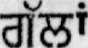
ਗੱਲਾਂ
